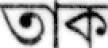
তাক
